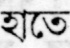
হাতে
